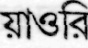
য়াওরি
